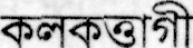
কলকত্তগী
